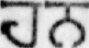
ਹਨ
